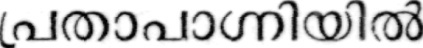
പ്രതാപാഗ്നിയില്‍
